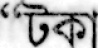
"টকা
